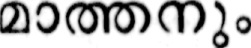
മാത്തനും
